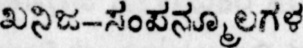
ಖನಿಜ-ಸಂಪನ್ಮೂಲಗಳ
